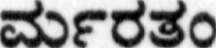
ರ್ಮರತಂ
